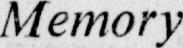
Memory
